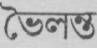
ভৈলন্ত
